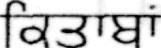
ਕਿਤਾਬਾਂ
